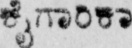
ಕೈಗಾರಿಕಾ
